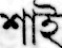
শাই
